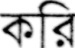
করি
